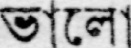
ভালো
